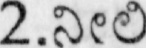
2.ನೀಲಿ
